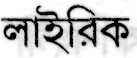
লাইরিক
